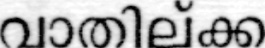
വാതില്ക്ക
